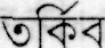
তর্কিব
